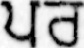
ਪਰ
